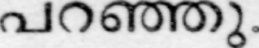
പറഞ്ഞു.
